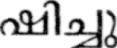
ഷിച്ചു
